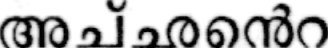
അച്ഛന്റെ
